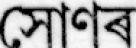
সোণৰ
